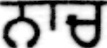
ਨਾਚ
